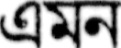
এমন
